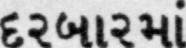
દરબારમાં
